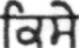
ਕਿਸੇ
